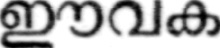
ഈവക
